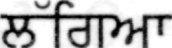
ਲੱਗਿਆ
